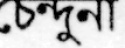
চেন্দুনা
